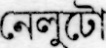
নেলুটো
